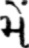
મેં
